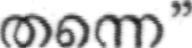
തന്നെ”
